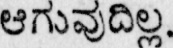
ಆಗುವುದಿಲ್ಲ.
